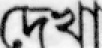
দেখা
